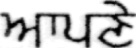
ਆਪਣੇ
